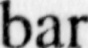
bar
